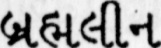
બ્રહ્મલીન
